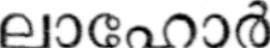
ലാഹോര്‍
